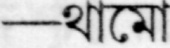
–থামো
